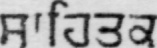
ਸਾਹਿਤਕ
